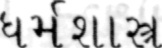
ધર્મશાસ્ત્ર
